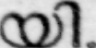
യി.
